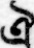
ঐ
